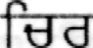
ਚਿਰ
